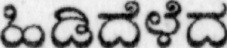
ಹಿಡಿದೆಳೆದ
